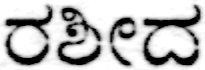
ರಶೀದ
